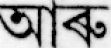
আৰু
